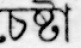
চেষ্টা
